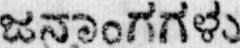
ಜನಾಂಗಗಳು
